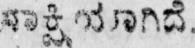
ಸಾಕ್ಷಿಯಾಗಿದೆ.
